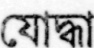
যোদ্ধা
